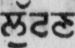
ਲੁੱਟਣ
